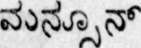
ಮನ್ಸೂನ್
